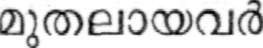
മുതലായവര്‍
